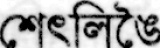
শেৎলিঙৈ
